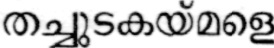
തച്ചുടകയ്മളെ
